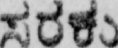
ಸರಕು
